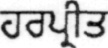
ਹਰਪ੍ਰੀਤ
